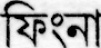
ফিংনা
